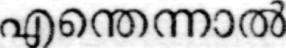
എന്തെന്നാല്‍
